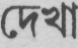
দেখা
